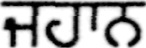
ਜਹਾਨ
